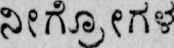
ನೀಗ್ರೋಗಳ
